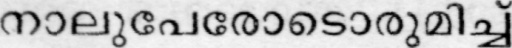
നാലുപേരോടൊരുമിച്ച്
